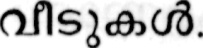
വീടുകള്‍.
